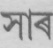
সাৰ
